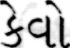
કેવો
